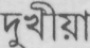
দুখীয়া
